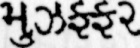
મુઝફ્ફર
